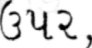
ઉપર,
